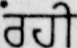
ਰਹੀ
